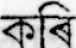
কৰি
